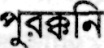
পুরক্কনি
